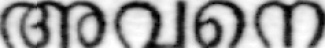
അവനെ
